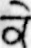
ਕੇ
